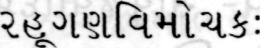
રહૂગણવિમેચકઃ
